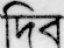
দিব
